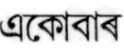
একোবাৰ
